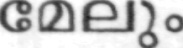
മേലും
